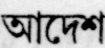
আদেশ
